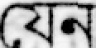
যেন
